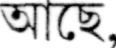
আছে,
